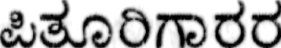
ಪಿತೂರಿಗಾರರ
